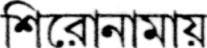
শিরোনামায়
